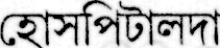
হোসপিটালদা
